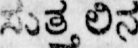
ಸುತ್ತಲಿನ
